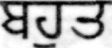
ਬਹੁਤ
